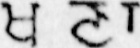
ਖਾਣਾ
